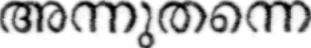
അന്നുതന്നെ
